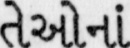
તેઓનાં
